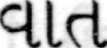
વાત
